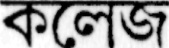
কলেজ
